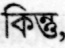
কিন্তু,
